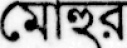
মোহুর
